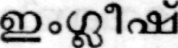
ഇംഗ്ലീഷ്
